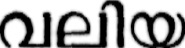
വലിയ
